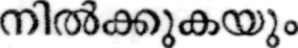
നില്‍ക്കുകയും
